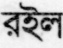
রইল
